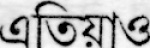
এতিয়াও
